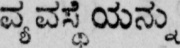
ವ್ಯವಸ್ಥೆಯನ್ನು
